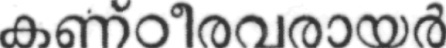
കണ്ഠീരവരായര്‍
